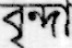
বৃন্দা
